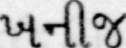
ખનીજ
